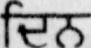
ਦਿਨ
